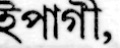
ইপাগী,
